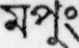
মপুং
